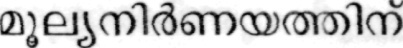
മൂല്യനിര്‍ണയത്തിന്
